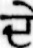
ਦੇ
